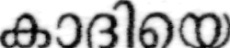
കാദിയെ
